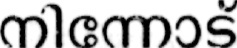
നിന്നോട്
